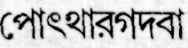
পোৎথারগদবা
